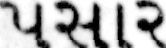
પસાર
